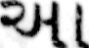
આ
